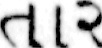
તાર
